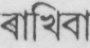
ৰাখিবা
